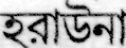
হরাউনা
